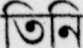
তিনি
